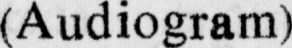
(Audiogram)
